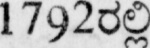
1792ರಲ್ಲಿ
